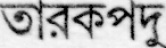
তারকপদু
